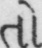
તો
